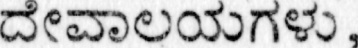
ದೇವಾಲಯಗಳು,
